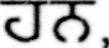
ਹਨ,
